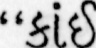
"કાંઈ
